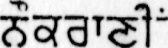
ਨੌਕਰਾਣੀਂ
